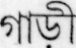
গাড়ী
